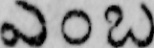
ಎಂಬ
